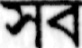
সব
